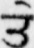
ਤੇ
